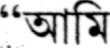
“আমি
